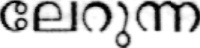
ലേറുന്ന
